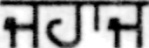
ਜਹਾਜ
